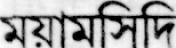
ময়ামসিদি
